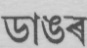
ডাঙৰ
